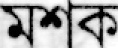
মশক
